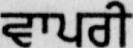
ਵਾਪਰੀ
